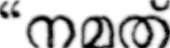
"നമത്
